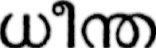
ധീന്ത
